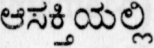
ಆಸಕ್ತಿಯಲ್ಲಿ
